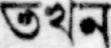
তখন
